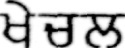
ਖੇਚਲ
